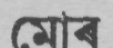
মোৰ
